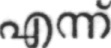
എന്ന്
